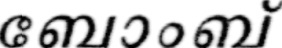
ബോംബ്
